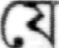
যে
